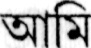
আমি
